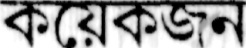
কয়েকজন
